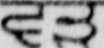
ਵੜ
